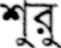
শুরু
